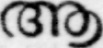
ആ
